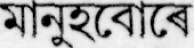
মানুহবোৰে
